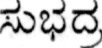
ಸುಭದ್ರ
